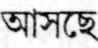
আসছে
